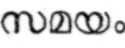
സമയം
